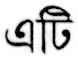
এটি
